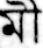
মী
